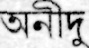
অনীদু
